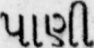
પાણી
